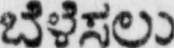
ಬೆಳೆಸಲು
